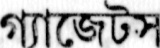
গ্যাজেটস
